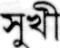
সুখী
